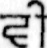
ਵੀ
